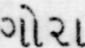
ગોરા
